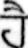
ਹੈ
